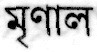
মৃণাল
